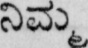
ನಿಮ್ಮ
